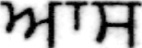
ਆਸ
